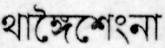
থাঙ্গৈশেংনা
